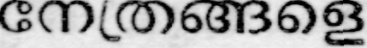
നേത്രങ്ങളെ
